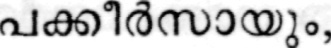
പക്കീര്‍സായും,
